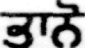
ਭਾਨੋ
